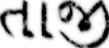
તાજી
